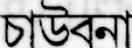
চাউবনা
